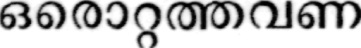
ഒരൊറ്റത്തവണ
